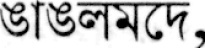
ঙাঙলমদে,
